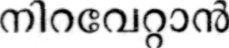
നിറവേറ്റാന്‍
